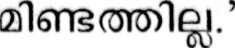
മിണ്ടത്തില്ല.’
